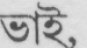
ভাই,
